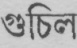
গুচিল
